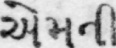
એમની
